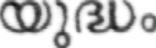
യുദ്ധം
